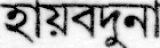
হায়বদুনা
